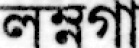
লম্নাগা
